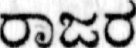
ರಾಜರ
